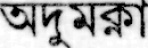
অদুমক্না
